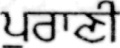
ਪੁਰਾਣੀ
